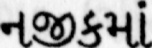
નજીકમાં
